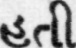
હતી
